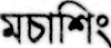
মচাশিং
